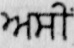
ਅਸੀਂ
